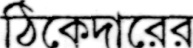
ঠিকেদারের
